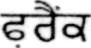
ਫ਼ਰੈਂਕ
